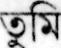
তুমি
